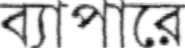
ব্যাপারে
